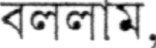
বললাম,
